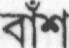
বাঁশ
